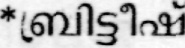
*ബ്രിട്ടീഷ്
